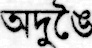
অদুঙৈ
